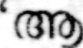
‘ആ
